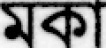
মকা
